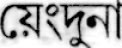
য়েংদুনা
